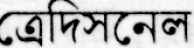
ত্রেদিসনেল
